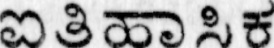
ಐತಿಹಾಸಿಕ
